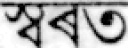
স্বৰত
